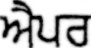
ਐਪਰ
